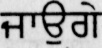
ਜਾਉਗੇ
